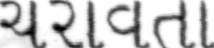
ચરાવતા
